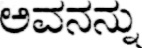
ಅವನನ್ನು
